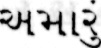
અમારું
